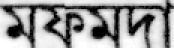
মফমদা
